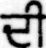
ਦੀ
